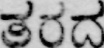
ತರದ
